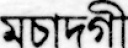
মচাদগী
